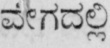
ವೇಗದಲ್ಲಿ
